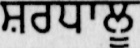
ਸ਼ਰਧਾਲੂ
